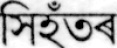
সিহঁতৰ
